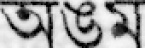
অঙম
